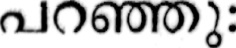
പറഞ്ഞു:
